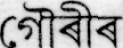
গৌৰীৰ
